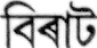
বিৰাট
